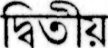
দ্বিতীয়
